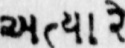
અત્યારે
